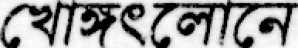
খোঙ্গৎলোনে
